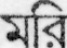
মরি
